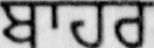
ਬਾਹਰ
